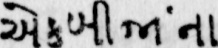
એકબીજાના
